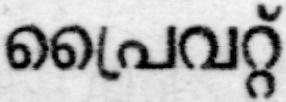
പ്രൈവറ്റ്
